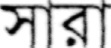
সারা
